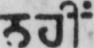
ਨਹੀਂ
